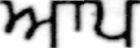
ਆਪ
